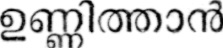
ഉണ്ണിത്താന്‍
